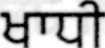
ਖਾਧੀ
